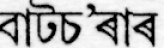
বাটচ'ৰাৰ
